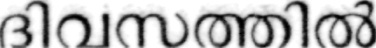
ദിവസത്തില്‍
